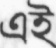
এই
